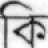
কি
